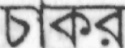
চাকর
